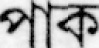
পাক
